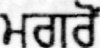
ਮਗਰੋਂ
